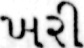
ખરી
